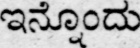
ಇನ್ನೊಂದು
